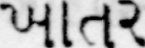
ખાતર
